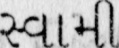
સ્વામી
